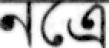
নত্রে
